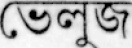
ভেলুজ
